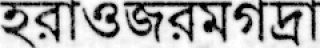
হরাওজরমগদ্রা
